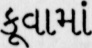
કૂવામાં
